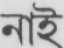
নাই
